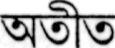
অতীত
